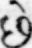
છે.
